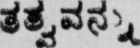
ತತ್ವವನ್ನು
